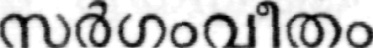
സര്‍ഗംവീതം
